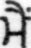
ਮੈਂ
